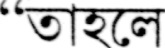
“তাহলে
